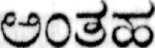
ಅಂತಹ
